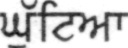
ਘੁੱਟਿਆ
